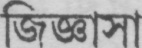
জিজ্ঞাসা
